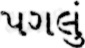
પગલું
